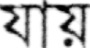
যায়
